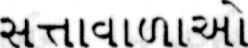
સત્તાવાળાઓ
